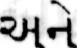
અને
